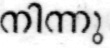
നിന്നു
